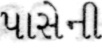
પાસેની
